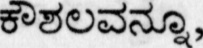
ಕೌಶಲವನ್ನೂ,
